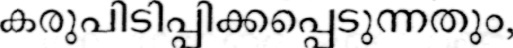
കരുപിടിപ്പിക്കപ്പെടുന്നതും,
